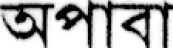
অপাবা
